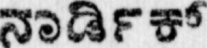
ನಾರ್ಡಿಕ್
